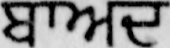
ਬਾਅਦ
